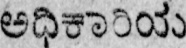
ಅಧಿಕಾರಿಯ
